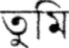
তুমি
